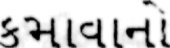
કમાવાનો
